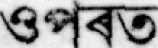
ওপৰত
